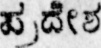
ಪ್ರದೇಶ
